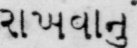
રાખવાનું
